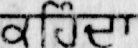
ਕਹਿੰਦਾ
